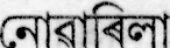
নোৱাৰিলা
